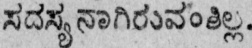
ಸದಸ್ಯನಾಗಿರುವಂತಿಲ್ಲ.
